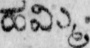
ಹಮ್ಮಿ
